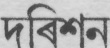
দৰিশন
